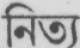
নিত্য
